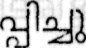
പ്പിച്ചു
